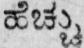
ಹೆಚ್ಚು
